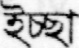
ইচ্ছা
